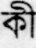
কী
